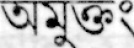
অমুক্তং
